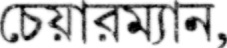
চেয়ারম্যান,
